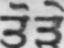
ਤੋੜੇ
